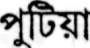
পুটিয়া
